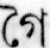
গৈ
